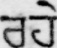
ਰਹੇ
